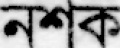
নশক
